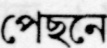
পেছনে
